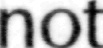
not
